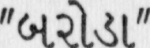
"બરોડા"
